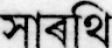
সাৰথি
